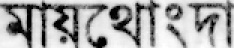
মায়থোংদা
